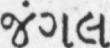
જંગલ
